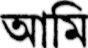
আমি
